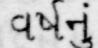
વર્ષનું
